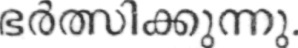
ഭര്‍ത്സിക്കുന്നു.
